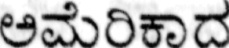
ಅಮೆರಿಕಾದ
